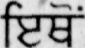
ਇਥੋਂ
